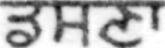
ਡਸਣਾ
